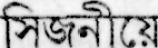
সিজনীয়ে
